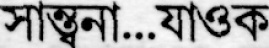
সান্ত্বনা...যাওক
